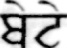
ਬੇਟੇ
